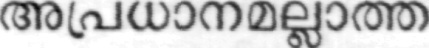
അപ്രധാനമല്ലാത്ത
